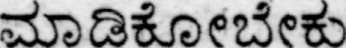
ಮಾಡಿಕೋಬೇಕು
